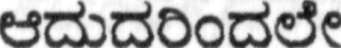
ಆದುದರಿಂದಲೇ
